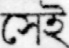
সেই
